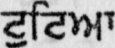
ਟੁਟਿਆ
